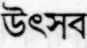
উত্সব
